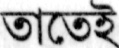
তাতেই
